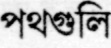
পথগুলি
